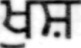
ਖੁਸ਼
